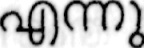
എന്നു
